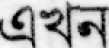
এখন
